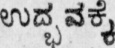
ಉದ್ಭವಕ್ಕೆ
